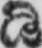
ಡಿ
